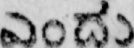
ಎಂದು
